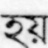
হয়
